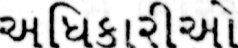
અધિકારીઓ
